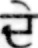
ਦੇ
